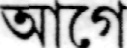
আগে
